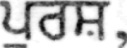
ਪੁਰਸ਼,
